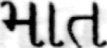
માત
